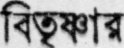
বিতৃষ্ণার
